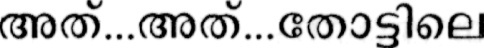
അത്...അത്...തോട്ടിലെ
